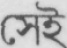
সেই
